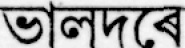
ভালদৰে
